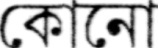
কোনো
